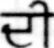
ਦੀ
